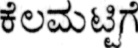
ಕೆಲಮಟ್ಟಿಗೆ
